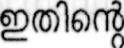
ഇതിന്റെ
